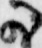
જે
